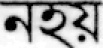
নহয়
